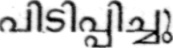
പിടിപ്പിച്ചു
